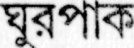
ঘুরপাক
